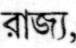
রাজ্য,
